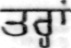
ਤਰ੍ਹਾਂ
